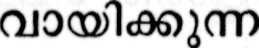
വായിക്കുന്ന
